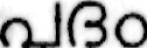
പദം
